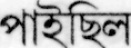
পাইছিল
